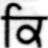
ਕਿ
